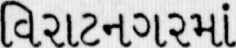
વિરાટનગરમાં
